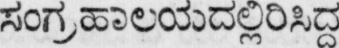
ಸಂಗ್ರಹಾಲಯದಲ್ಲಿರಿಸಿದ್ದ
